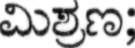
ಮಿಶ್ರಣ;
